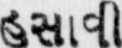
હસાવી
